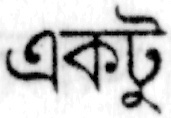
একটু
